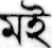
মই
